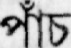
পাঁচ
